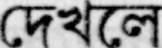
দেখলে
